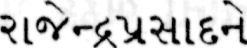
રાજેન્દ્રપ્રસાદને
